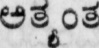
ಅತ್ಯಂತ
